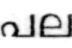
പല
